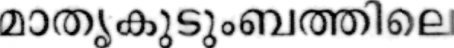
മാതൃകുടുംബത്തിലെ
